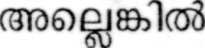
അല്ലെങ്കില്‍
